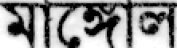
মাঙ্গোল
